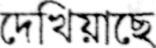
দেখিয়াছে
